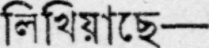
লিখিয়াছে—
